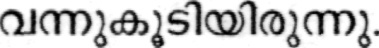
വന്നുകൂടിയിരുന്നു.
